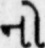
નો
